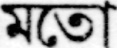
মতো
